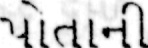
પોતાની
